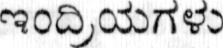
ಇಂದ್ರಿಯಗಳು
